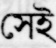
সেই
